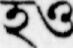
হও
